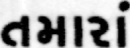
તમારાં
